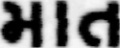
માત
